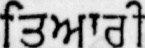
ਤਿਆਰੀ
